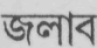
জলাব
